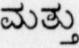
ಮತ್ತು
